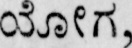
ಯೋಗ,
